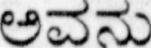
ಅವನು
